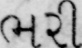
ભરી
